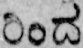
ರಿಂದ
